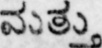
ಮತ್ತು
